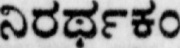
ನಿರರ್ಥಕಂ
